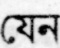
যেন
